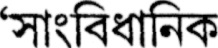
‘সাংবিধানিক
